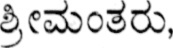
ಶ್ರೀಮಂತರು,
